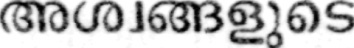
അശ്വങ്ങളുടെ
